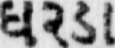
ધરડા
